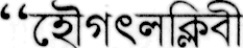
“হৌগৎলক্লিবী
